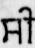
ਸੀ
